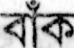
বাঁক
